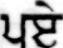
ਪਏ
